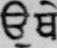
ਉਥੇ
